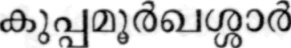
കുപ്പമൂര്‍ഖശ്ശാര്‍
